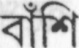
বাঁশি
